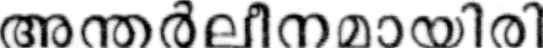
അന്തര്‍ലീനമായിരി
